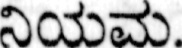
ನಿಯಮ.
